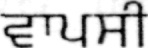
ਵਾਪਸੀ
